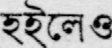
হইলেও
